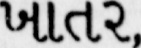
ખાતર,
